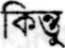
কিন্তু
